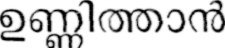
ഉണ്ണിത്താന്‍
